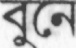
বুনে
